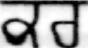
ਕਰ
